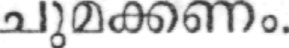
ചുമക്കണം.
